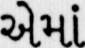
એમાં
